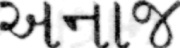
અનાજ
